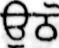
ਉਠੋ
